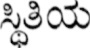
ಸ್ಥಿತಿಯ
